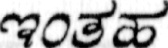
ಇಂತಹ
